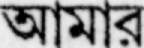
আমার
